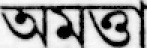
অমত্তা
